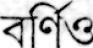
বর্ণিও
